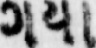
ગયા
